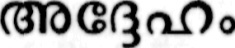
അദ്ദേഹം
